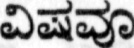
ವಿಷವೂ
